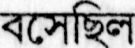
বসেছিল
